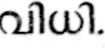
വിധി.
